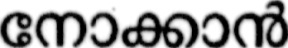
നോക്കാന്‍
